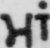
ਮਾਂ
